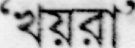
‘খয়রা’
